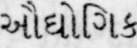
ઔધોગિક
